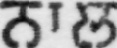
ਨਾਲ
